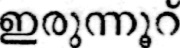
ഇരുന്നൂറ്
